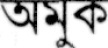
অমুক
